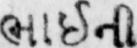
ભાઈની
